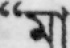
"মা
